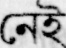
নেই
